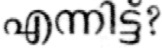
എന്നിട്ട്?
